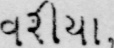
વરીયા,
